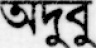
অদুবু
